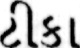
ટીકા
